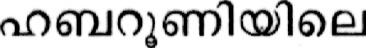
ഹബറൂണിയിലെ
